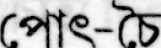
পোৎ-চৈ
